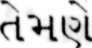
તેમણે
